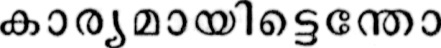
കാര്യമായിട്ടെന്തോ
